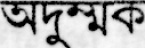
অদুম্মক
